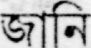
জানি
